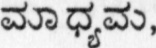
ಮಾಧ್ಯಮ,
